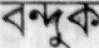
বন্দুক
